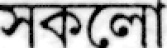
সকলো
